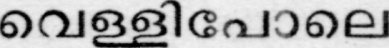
വെള്ളിപോലെ
